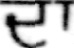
ਦਾ
